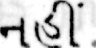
નહીં.
